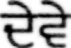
ਦੇਵੇ
